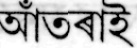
আঁতৰাই
